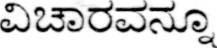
ವಿಚಾರವನ್ನೂ
